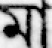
মা
